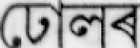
ঢোলৰ
